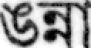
ঙন্না
